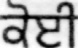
ਕੋਈ
